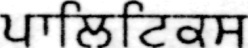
ਪਾਲਿਟਿਕਸ
